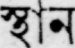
স্থান
